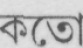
কতো
